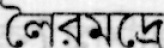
লৈরমদ্রে
